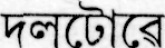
দলটোৱে
